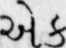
એક
